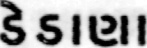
ડેડાણા
